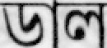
ডাল
